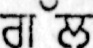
ਗੱਲ
